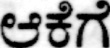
ಆಕೆಗೆ
